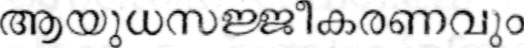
ആയുധസജ്ജീകരണവും
